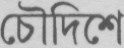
চৌদিশে
